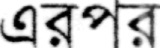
এরপর
